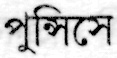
পুন্সিসে
